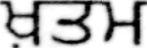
ਖ਼ਤਮ
